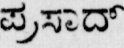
ಪ್ರಸಾದ್
